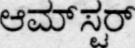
ಆಮ್‌ಸ್ಟರ್
